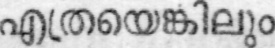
എത്രയെങ്കിലും
